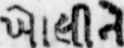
ખોલીને
